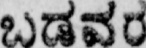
ಬಡವರ
